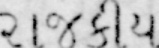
રાજકીય
